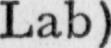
Lab)
